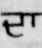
ਦਾ
